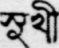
সুখী
